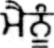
ਮੈਨੂੰ
